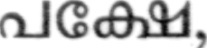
പക്ഷേ,
